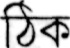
ঠিক
